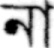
না
